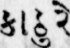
કાઠુરે
